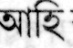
আহি
